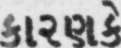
કારણકે
